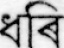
ধৰি
